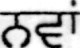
ਨਵਾਂ
